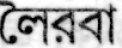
লৈরবা
